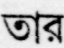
তার
